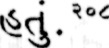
હતું.૨૦૮
